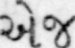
એજ
